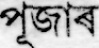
পূজাৰ
